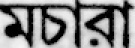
মচারা
